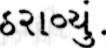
ઠરાવ્યું.
